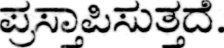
ಪ್ರಸ್ತಾಪಿಸುತ್ತದೆ.
